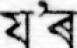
য'ৰ
